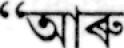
"আৰু
